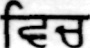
ਵਿਚ
